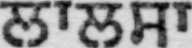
ਲਾਲਸਾ
